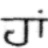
ਹਾਂ
